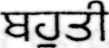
ਬਹੁਤੀ
